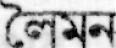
লৈমন
